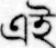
এই
